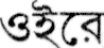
ওইরে
